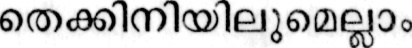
തെക്കിനിയിലുമെല്ലാം
